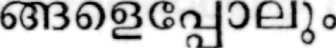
ങ്ങളെപ്പോലും
